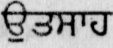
ਉਤਸਾਹ
